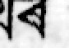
খৰ
